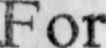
For
